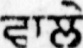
ਵਾਲੇ
